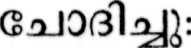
ചോദിച്ചു:
